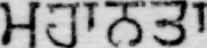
ਮਹਾਨਤਾ
